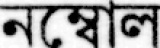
নম্বোল
